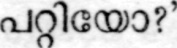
പറ്റിയോ?’
